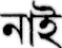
নাই
